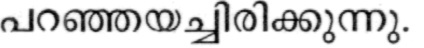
പറഞ്ഞയച്ചിരിക്കുന്നു.
